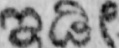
ಇಡೀ
